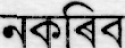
নকৰিব
